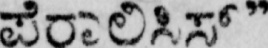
ಪೆರಾಲಿಸಿಸ್”
